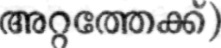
അറ്റത്തേക്ക്)
